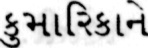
કુમારિકાને
